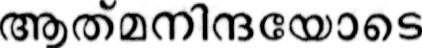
ആത്മനിന്ദയോടെ
